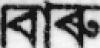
বাৰু
